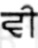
ਵੀ
